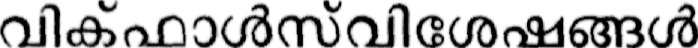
വിക്ഫാള്‍സ്വിശേഷങ്ങള്‍
